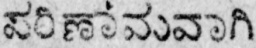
ಪರಿಣಾಮವಾಗಿ
